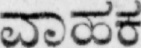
ವಾಹಕ
